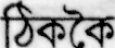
ঠিককৈ
